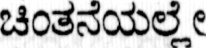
ಚಿಂತನೆಯಲ್ಲೇ
